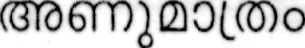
അണുമാത്രം
